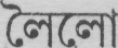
লৈলো
